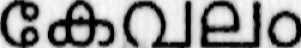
കേവലം
